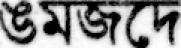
ঙমজদে
